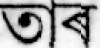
তাৰ
